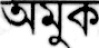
অমুক
